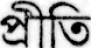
প্রীতি
